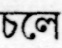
চলে
